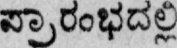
ಪ್ರಾರಂಭದಲ್ಲಿ
